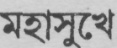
মহাসুখে
